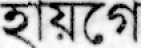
হায়গে
